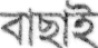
বাছাই
